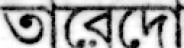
তারেদো
